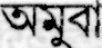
অমুবা
